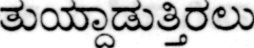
ತುಯ್ದಾಡುತ್ತಿರಲು
